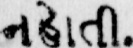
નહોતી.
